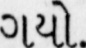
ગયો.
